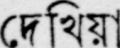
দেখিয়া
